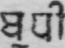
ਬੁਧੀ
